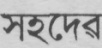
সহদেৱ
